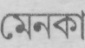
মেনকা
